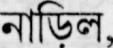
নাড়িল,
